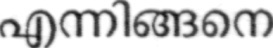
എന്നിങ്ങനെ
